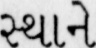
સ્થાને
